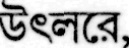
উৎলরে,
